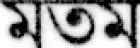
মতম
